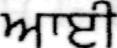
ਆਈ
